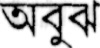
অবুঝ
